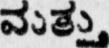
ಮತ್ತು
